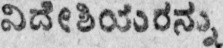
ವಿದೇಶಿಯರನ್ನು
